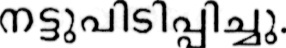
നട്ടുപിടിപ്പിച്ചു.
